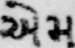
એમ
